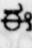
ಈ
